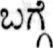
ಬಗ್ಗೆ
